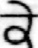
ਕੇ
